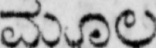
ಮೂಲ
